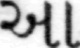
આ
